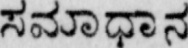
ಸಮಾಧಾನ
